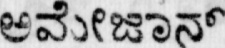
ಅಮೇಜಾನ್
